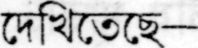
দেখিতেছে—
